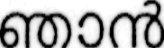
ഞാന്‍
